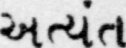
અત્યંત
